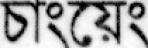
চাংয়েং
